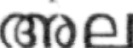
അല
